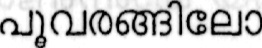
പൂവരങ്ങിലോ
